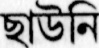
ছাউনি
